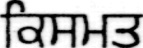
ਕਿਸਮਤ
